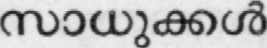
സാധുക്കള്‍
